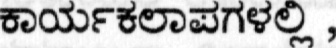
ಕಾರ್ಯಕಲಾಪಗಳಲ್ಲಿ,
